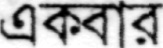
একবার
